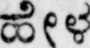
ಹೇಳ
